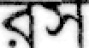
রস
